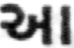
આ
